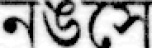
নঙসে
